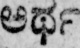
ಅರ್ಥ
